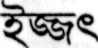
ইজ্জত্
